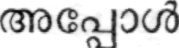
അപ്പോള്‍
